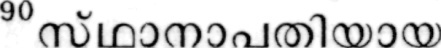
90സ്ഥാനാപതിയായ
